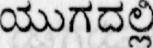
ಯುಗದಲ್ಲಿ
